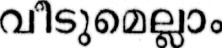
വീടുമെല്ലാം
